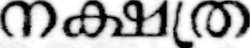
നക്ഷത്ര
